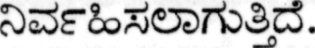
ನಿರ್ವಹಿಸಲಾಗುತ್ತಿದೆ.
